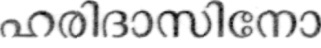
ഹരിദാസിനോ
